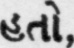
હતો,
